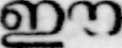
ഈ
